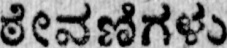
ಠೇವಣಿಗಳು
